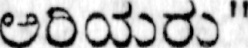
ಅರಿಯರು”
